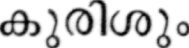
കുരിശും
